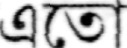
এতো
